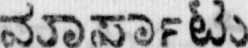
ಮಾರ್ಪಾಟು
